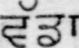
ਵੱਡਾ
